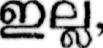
ഇല്ല,
